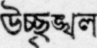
উচ্ছৃঙ্খল
